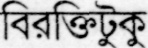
বিরক্তিটুকু
